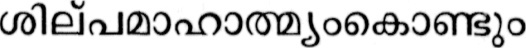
ശില്പമാഹാത്മ്യംകൊണ്ടും
